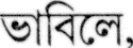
ভাবিলে,
